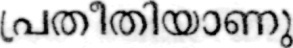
പ്രതീതിയാണു
